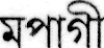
মপাগী
